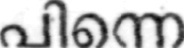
പിന്നെ
